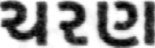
ચરણ
